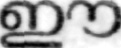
ഈ
